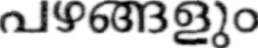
പഴങ്ങളും
